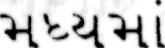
મધ્યમાં
